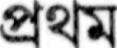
প্রথম
